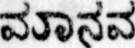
ಮಾನವ
